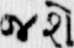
જશે
